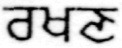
ਰਖਣ
